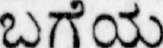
ಬಗೆಯ
